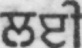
ਲਈ
